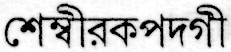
শেম্বীরকপদগী
